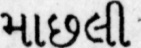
માછલી
